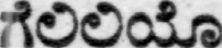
ಗೆಲಿಲಿಯೊ
